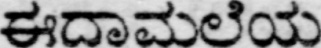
ಈದಾಮಲೆಯ
